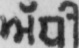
ਅੱਧੀ
